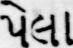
પેલા
